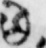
છે.
